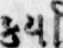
કર્યા
